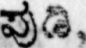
ಪುಡಿ,
